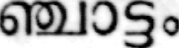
ഞ്ചാട്ടം
